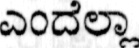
ಎಂದೆಲ್ಲಾ
